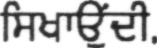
ਸਿਖਾਉਂਦੀ,
